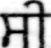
ਸੀ
